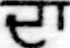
ਦਾ
